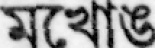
মখোঙ
